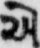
એ
